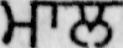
ਮਾਲ
